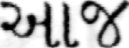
આજ
